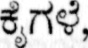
ಕೈಗಳೆ,
